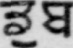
ਡੁਬ
